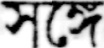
সঙ্গে
